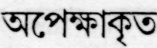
অপেক্ষাকৃত
